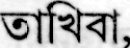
তাখিবা,
